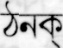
ঠনক্
